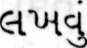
લખવું
